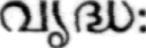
വൃദ്ധ:
